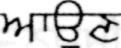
ਆਉਣ
